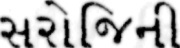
સરોજિની
